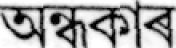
অন্ধকাৰ
